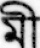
মী
